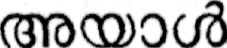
അയാള്‍
